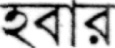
হবার
